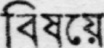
বিষয়ে
